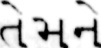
તેમને
